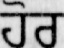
ਹੋਰ
